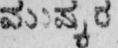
ಮುಷ್ಕರ
